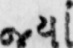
જ્યાં
